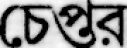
চেপ্তর
